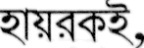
হায়রকই,
